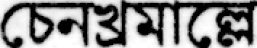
চেনখ্রমাল্লে
